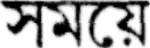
সময়ে
